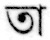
তা
